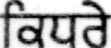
ਕਿਧਰੇ
